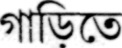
গাড়িতে
